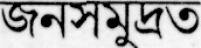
জনসমুদ্রত
